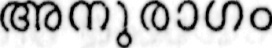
അനുരാഗം
